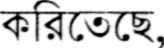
করিতেছে,
